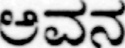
ಅವನ
